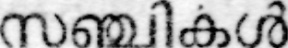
സഞ്ചികള്‍
